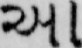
આ
